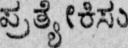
ಪ್ರತ್ಯೇಕಿಸು
